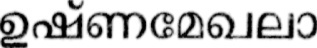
ഉഷ്ണമേഖലാ
